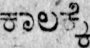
ಕಾಲಕ್ಕೆ
